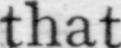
that
